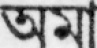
অমা
